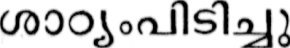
ശാഠ്യംപിടിച്ചു
